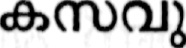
കസവു
